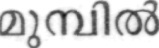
മുമ്പില്‍
